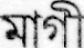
মাগী
